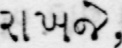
રાખજે,
